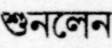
শুনলেন
